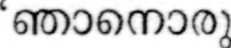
‘ഞാനൊരു
